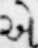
એ
